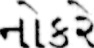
નોકરે
